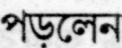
পড়লেন
